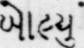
બોલ્યું
